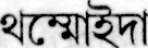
থম্মোইদা
